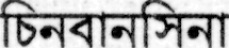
চিনবানসিনা
